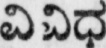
ವಿವಿಧ
